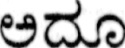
ಅದೂ
